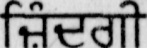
ਜ਼ਿੰਦਗੀ
